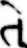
તે
